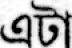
এটা
